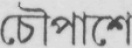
চৌপাশে
